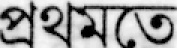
প্রথমতে
